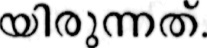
യിരുന്നത്.
